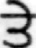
ਤੇ
